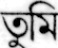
তুমি
